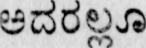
ಅದರಲ್ಲೂ
